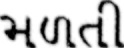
મળતી
